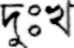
দুঃখ
